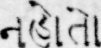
નહોતો
